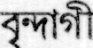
বৃন্দাগী
